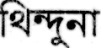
থিন্দুনা
